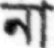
না
